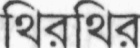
থিরথির
